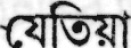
যেতিয়া
